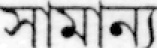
সামান্য
